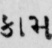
કામ
